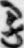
કે
